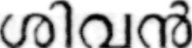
ശിവന്‍
